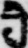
ਹੈ
